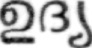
ഉദ്യ
